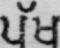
ਪੱਖ
